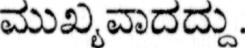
ಮುಖ್ಯವಾದದ್ದು.
